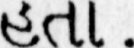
હતા.
